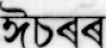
ঈচৰৰ
